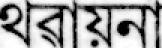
থৱায়না
